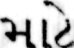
માટે
